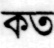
কত
